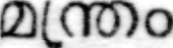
മന്ത്രം
